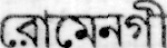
রোমেনগী
